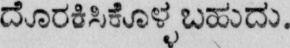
ದೊರಕಿಸಿಕೊಳ್ಳಬಹುದು.
